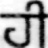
ਹੀ
